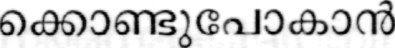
ക്കൊണ്ടുപോകാന്‍
